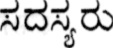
ಸದಸ್ಯರು
